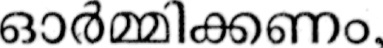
ഓര്‍മ്മിക്കണം.
